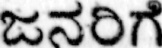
ಜನರಿಗೆ
